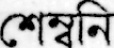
শেম্বনি
